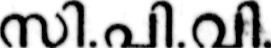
സി.പി.വി.
